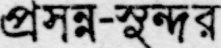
প্রসন্ন-সুন্দর
